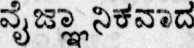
ವೈಜ್ಞಾನಿಕವಾದ
